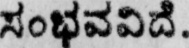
ಸಂಭವವಿದೆ.
